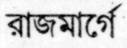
রাজমার্গে
